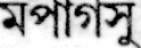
মপাগসু
